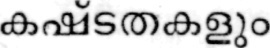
കഷ്ടതകളും
